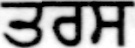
ਤਰਸ
